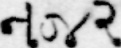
નજર
